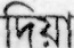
দিয়া
